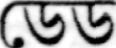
ডেড
